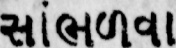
સાંભળવા
